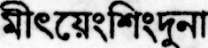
মীৎয়েংশিংদুনা
